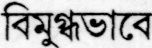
বিমুগ্ধভাবে
